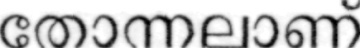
തോന്നലാണ്
